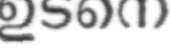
ഉടനെ
